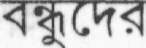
বন্ধুদের
